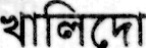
খালিদো
